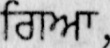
ਗਿਆ,
